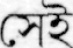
সেই
